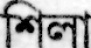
শিলা
